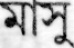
মাসু
